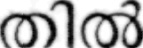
തില്‍
